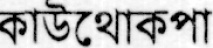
কাউথোকপা
